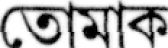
তোমাক
